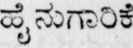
ಹೈನುಗಾರಿಕೆ
